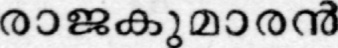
രാജകുമാരന്‍
